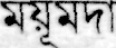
ময়ূমদা
